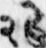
રહે
